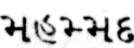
મહમ્મદ
